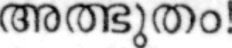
അത്ഭുതം!
